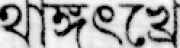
থাঙ্গৎখ্রে
